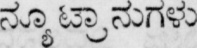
ನ್ಯೂಟ್ರಾನುಗಳು
